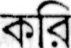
করি
